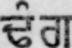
ਢੰਗ
